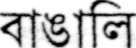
বাঙালি
